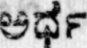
ಅರ್ಧ
